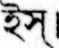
ইস্।
